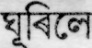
ঘূৰিলে
